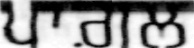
ਪਾਗ਼ਲ
